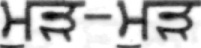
ਮੁੜ-ਮੁੜ
